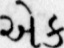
એક
